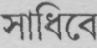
সাধিবে
